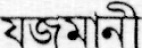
যজমানী
